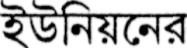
ইউনিয়নের
